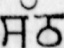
ਸੱਠ
